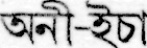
অনী-ইচা
